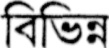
বিভিন্ন
